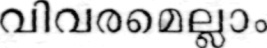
വിവരമെല്ലാം
